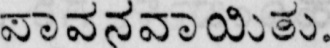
ಪಾವನವಾಯಿತು.
